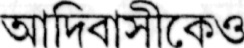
আদিবাসীকেও
